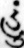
હું
